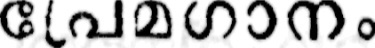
പ്രേമഗാനം
